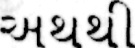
અથથી
